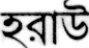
হরাউ
